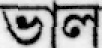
ভাল
